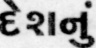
દેશનું
